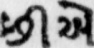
છીએ
